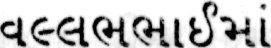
વલ્લભભાઈમાં
